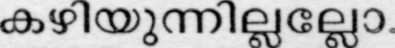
കഴിയുന്നില്ലല്ലോ.
